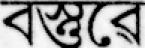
বস্তুৱে
